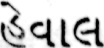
હેવાલ
